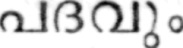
പദവും
